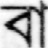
বা
